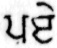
ਪਏ
